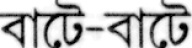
বাটে-বাটে
